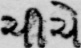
ચીચે
